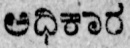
ಅಧಿಕಾರ
